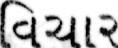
વિચાર
